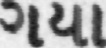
ગયા
